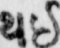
થઈ
